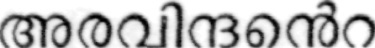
അരവിന്ദന്റെ
